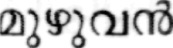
മുഴുവന്‍
